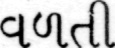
વળતી
